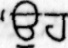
'ਉਹ
